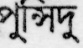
পুন্সিদু
